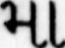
મા
